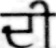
ਦੀ
